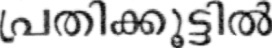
പ്രതിക്കൂട്ടില്‍
